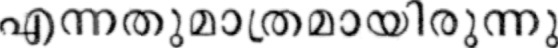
എന്നതുമാത്രമായിരുന്നു
